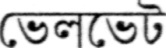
ভেলভেট
